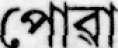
পোৱা
